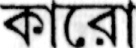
কারো
